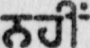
ਨਹੀਂ
